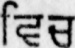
ਵਿਚ
